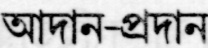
আদান-প্রদান
